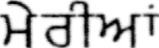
ਮੇਰੀਆਂ
